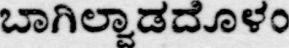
ಬಾಗಿಲ್ವಾಡದೊಳಂ
